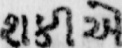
શકીએ
